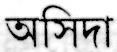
অসিদা
